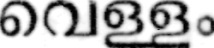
വെള്ളം
